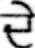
ਦੇ
